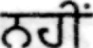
ਨਹੀਂ
